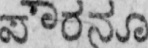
ಪೌರನೂ
